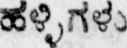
ಹಳ್ಳಿಗಳು
